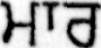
ਮਾਰ
